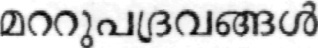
മററുപദ്രവങ്ങള്‍
